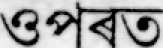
ওপৰত
